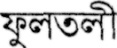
ফুলতলী
